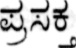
ಪ್ರಸಕ್ತ
